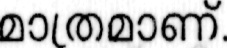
മാത്രമാണ്.
